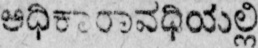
ಅಧಿಕಾರಾವಧಿಯಲ್ಲಿ
